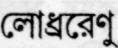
লোধ্ররেণু
